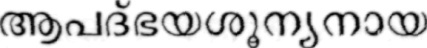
ആപദ്ഭയശൂന്യനായ
